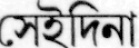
সেইদিনা
